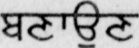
ਬਣਾਉਣ
